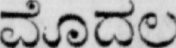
ಮೊದಲ
